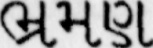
ભ્રમણ
